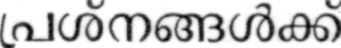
പ്രശ്നങ്ങള്‍ക്ക്
